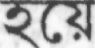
হয়ে
